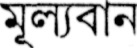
মূল্যবান
